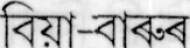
বিয়া-বাৰুৰ
